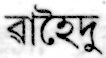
ৱাহৈদু
